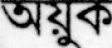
অয়ুক
